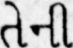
તેની
